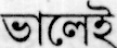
ভালেই
